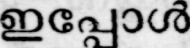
ഇപ്പോള്‍
